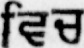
ਵਿਚ
